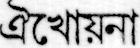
ঐখোয়না
